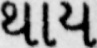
થાય
